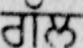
ਗੱਲ
